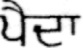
ਪੈਦਾ
